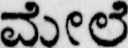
ಮೇಲೆ
